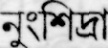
নুংশিদ্রা
